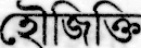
হৌজিক্তি
